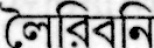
লৈরিবনি
